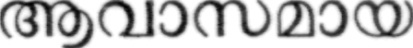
ആവാസമായ
